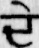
ਦੇ
